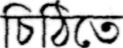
চিঠিতে
